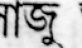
সাজু
